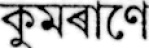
কুমৰাণে
